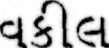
વકીલ
